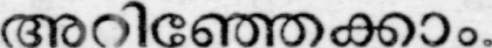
അറിഞ്ഞേക്കാം.
